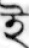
ই
